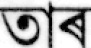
তাৰ
